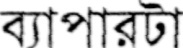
ব্যাপারটা
